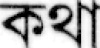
কথা
